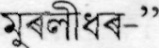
মুৰলীধৰ-"
